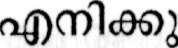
എനിക്കു
